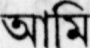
আমি
